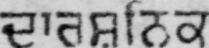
ਦਾਰਸ਼ਨਿਕ
